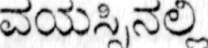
ವಯಸ್ಸಿನಲ್ಲಿ
